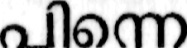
പിന്നെ
